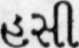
હસી
